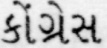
કોંગ્રેસ
